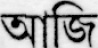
আজি
